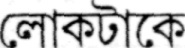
লোকটাকে
